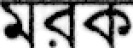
মরক
